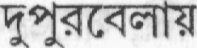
দুপুরবেলায়
